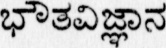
ಭೌತವಿಜ್ಞಾನ
